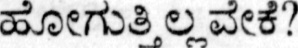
ಹೋಗುತ್ತಿಲ್ಲವೇಕೆ?
